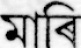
মাৰি
